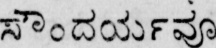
ಸೌಂದರ್ಯವೂ
